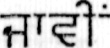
ਜਾਵੀਂ
